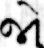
જો
